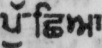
ਪੁੱਛਿਆ
